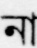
না
